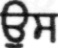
ਉਸ
